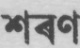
শৰণ
